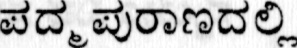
ಪದ್ಮಪುರಾಣದಲ್ಲಿ
